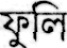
ফুলি
